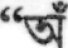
"অঁ
